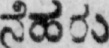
ನೆಹರು
